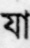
যা
